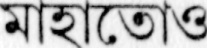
মাহাতোও
